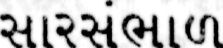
સારસંભાળ
